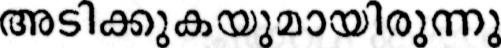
അടിക്കുകയുമായിരുന്നു
